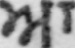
ਆ
